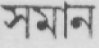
সমান
